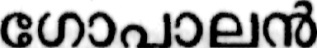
ഗോപാലന്‍
